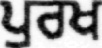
ਪੁਰਖ
